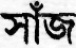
সাঁজ
